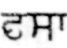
ਫਸਾ
